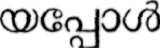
യപ്പോള്‍
